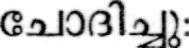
ചോദിച്ചു:
